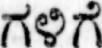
ಗಳಿಗೆ
